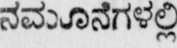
ನಮೂನೆಗಳಲ್ಲಿ
